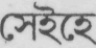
সেইহে
